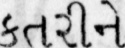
કતરીને
